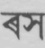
ৰস
